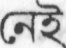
নেই
